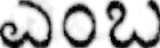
ಎಂಬ
